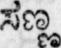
ಸಣ್ಣ
